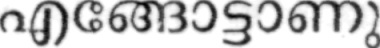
എങ്ങോട്ടാണു
